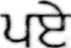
ਪਏ
